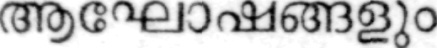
ആഘോഷങ്ങളും
